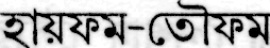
হায়ফম-তৌফম
